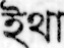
ইথা
